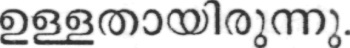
ഉള്ളതായിരുന്നു.
